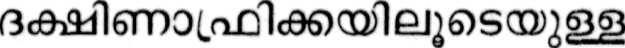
ദക്ഷിണാഫ്രിക്കയിലൂടെയുള്ള
